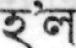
হ'ল
